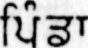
ਪਿੰਡਾ
